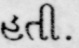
હતી.
